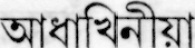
আধাখিনীয়া
